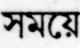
সময়ে
